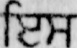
ਇਸ
